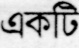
একটি
